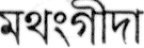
মথংগীদা
